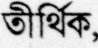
তীর্থিক,
